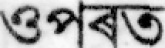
ওপৰত
